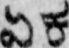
ಏಕ
